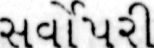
સર્વોપરી
